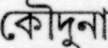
কৌদুনা
